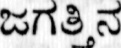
ಜಗತ್ತಿನ
